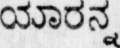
ಯಾರನ್ನ
